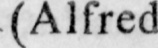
(Alfred
